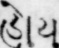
હોય
